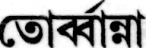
তোর্ব্বান্না
